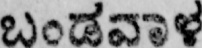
ಬಂಡವಾಳ
